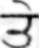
ਤੇ
